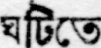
ঘটিতে
